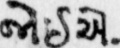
જોઈએ.
